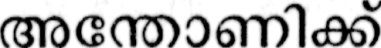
അന്തോണിക്ക്
